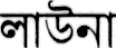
লাউনা
